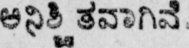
ಅನಿಶ್ಚಿತವಾಗಿವೆ.
